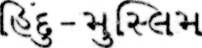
હિંદુ-મુસ્લિમ
